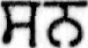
ਸਨ
